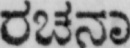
ರಚನಾ
